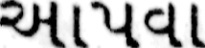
આપવા
